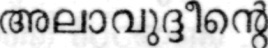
അലാവുദ്ദീന്റെ
